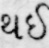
થઈ
